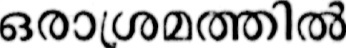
ഒരാശ്രമത്തില്‍
